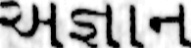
અજ્ઞાન
